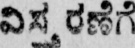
ವಿಸ್ತರಣೆಗೆ
